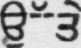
ਉੱਤੇ
